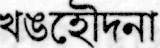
খঙহৌদনা
